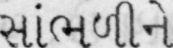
સાંભળીને
